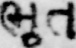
ભૂત
